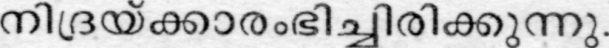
നിദ്രയ്ക്കാരംഭിച്ചിരിക്കുന്നു.
